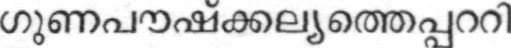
ഗുണപൌഷ്ക്കല്യത്തെപ്പററി
